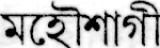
মহৌশাগী
